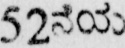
52ನೆಯ
